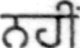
ਨਹੀਂ
